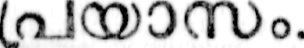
പ്രയാസം.
